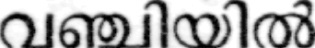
വഞ്ചിയില്‍
